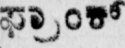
ಫ್ರಾಂಕ್
